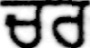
ਚਰ
